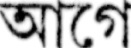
আগে
